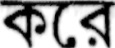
করে
